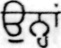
ਉਨ੍ਹਾਂ
